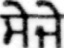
ਸੇਜੇ
